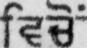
ਵਿਚੋਂ
